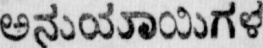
ಅನುಯಾಯಿಗಳ
